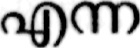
എന്ന
